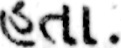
હતા.
